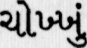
ચોખ્ખું
